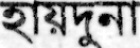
হায়দুনা
